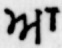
ਆ
